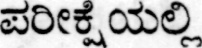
ಪರೀಕ್ಷೆಯಲ್ಲಿ
